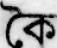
কৈ
